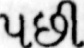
પછી
